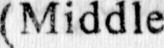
(Middle
